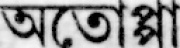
অতোপ্পা
